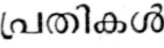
പ്രതികള്‍
